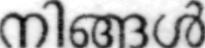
നിങ്ങള്‍
